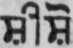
ਸ਼ੀਸ਼ੋ
